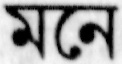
মনে
